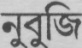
নুবুজি
